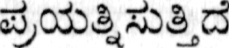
ಪ್ರಯತ್ನಿಸುತ್ತಿದೆ
